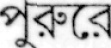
পুরুরে
